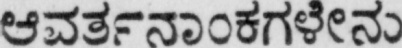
ಆವರ್ತನಾಂಕಗಳೇನು
